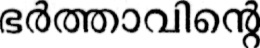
ഭര്‍ത്താവിന്റെ
